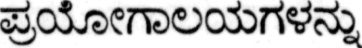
ಪ್ರಯೋಗಾಲಯಗಳನ್ನು
